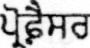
ਪ੍ਰੋਫ਼ੈਸਰ
